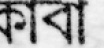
কাবা
